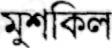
মুশকিল
